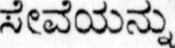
ಸೇವೆಯನ್ನು
